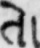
તો
